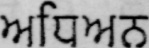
ਅਧਿਅਨ
